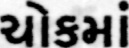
ચોકમાં
